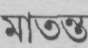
মাতন্ত
